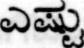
ಎಷ್ಟು
